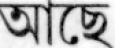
আছে
